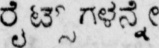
ರೈಟ್ಸ್‌ಗಳನ್ನೇ
